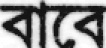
বাবে
